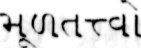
મૂળતત્ત્વો
